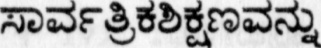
ಸಾರ್ವತ್ರಿಕಶಿಕ್ಷಣವನ್ನು
